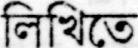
লিখিতে
